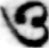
ও
